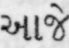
આજે
